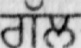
ਗੱਲ
